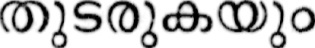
തുടരുകയും
